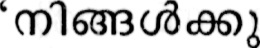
‘നിങ്ങള്‍ക്കു
